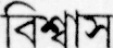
বিশ্বাস
